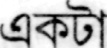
একটা
